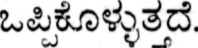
ಒಪ್ಪಿಕೊಳ್ಳುತ್ತದೆ.
